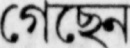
গেছেন
